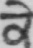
ਕੇ
